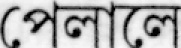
পেলালে
